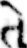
તે
